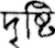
দৃষ্টি
